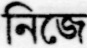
নিজে
